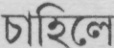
চাহিলে
